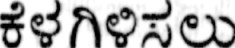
ಕೆಳಗಿಳಿಸಲು
